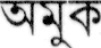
অমুক
